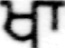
ਖਾ
